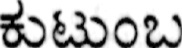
ಕುಟುಂಬ
